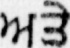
ਅਤੇ
